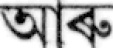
আৰু
